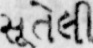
સૂતેલી
